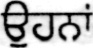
ਉਹਨਾਂ
